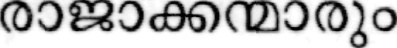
രാജാക്കന്മാരും
